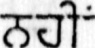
ਨਹੀਂ
